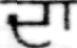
ਦਾ
